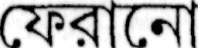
ফেরানো
